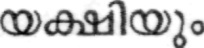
യക്ഷിയും
